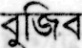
বুজিব
